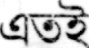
এতই
